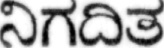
ನಿಗದಿತ
